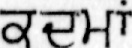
ਕਦਮਾਂ
